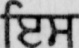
ਇਸ
